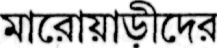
মারোয়াড়ীদের
